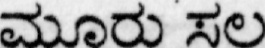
ಮೂರುಸಲ
